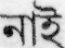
নাই
